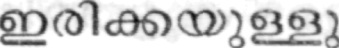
ഇരിക്കയുള്ളു
